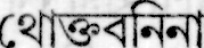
থোক্তবনিনা
